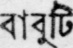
বাবুটি
